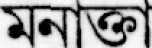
মনাক্তা
